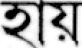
হায়
